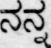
ನನ್ನ
